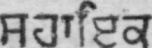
ਸਹਾਇਕ
